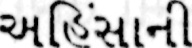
અહિંસાની
